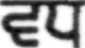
ਵਧ
